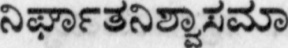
ನಿರ್ಘಾತನಿಶ್ವಾಸಮಾ
